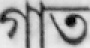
গাত
